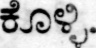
ಕೊಳ್ಳಿ.
